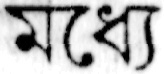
মধ্যে
